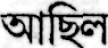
আছিল
